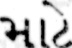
માટે
